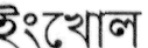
ইংখোল
